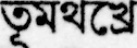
তূমথখ্রে
